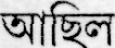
আছিল
